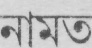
নামত
